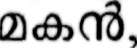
മകന്‍,
